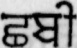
ਛਬੀ
